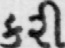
કરી
